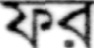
ফর
